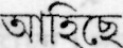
আহিছে
